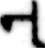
ન
